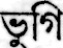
ভুগি
